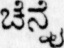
ಚೆನ್ನೈ
